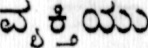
ವ್ಯಕ್ತಿಯು
